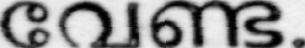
വേണ്ട.
